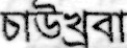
চাউখ্রবা
